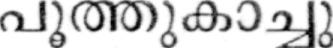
പൂത്തുകാച്ചു
